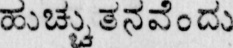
ಹುಚ್ಚುತನವೆಂದು
